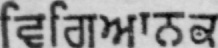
ਵਿਗਿਆਨਕ
